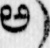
ಅ)
